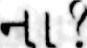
ના?
